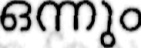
ഒന്നും
